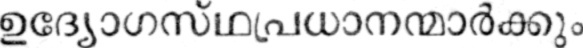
ഉദ്യോഗസ്ഥപ്രധാനന്മാര്‍ക്കും
